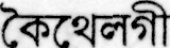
কৈথেলগী
